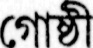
গোষ্ঠী
